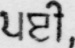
ਪਈ,
